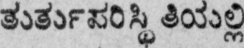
ತುರ್ತುಪರಿಸ್ಥಿತಿಯಲ್ಲಿ
